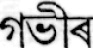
গভীৰ
